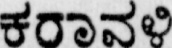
ಕರಾವಳಿ
